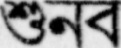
শুনব
